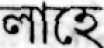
লাহে
